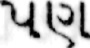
પણ
